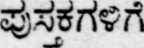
ಪುಸ್ತಕಗಳಿಗೆ
